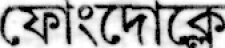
ফোংদোক্লে
